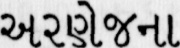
અરણેજના
